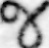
જ
